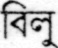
বিলু
